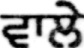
ਵਾਲੇ
